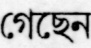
গেছেন
